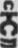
ਨੂੰ
